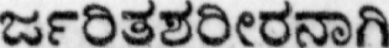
ರ್ಜರಿತಶರೀರನಾಗಿ
